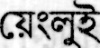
য়েংলুই
